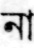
না
